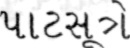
પાટસૂત્રે
